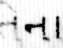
તેના
